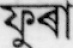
ফুৰা
